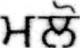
ਮਲੋ
